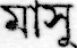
মাসু
